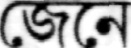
জেনে
